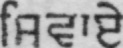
ਸਿਵਾਏ
